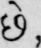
છે,
